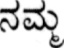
ನಮ್ಮ
